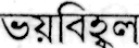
ভয়বিহ্বল
